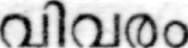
വിവരം
